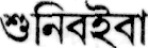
শুনিবইবা
